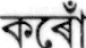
কৰোঁ
